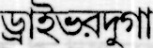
ড্রাইভরদুগা
